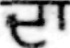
ਦਾ
